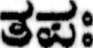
ತಪಃ
